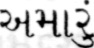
અમારું
